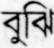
বুঝি
